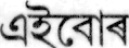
এইবোৰ
